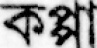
কপ্পা
